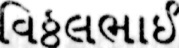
વિઠ્ઠલભાઈ
